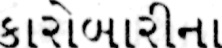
કારોબારીના
